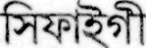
সিফাইগী
